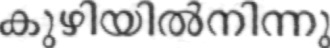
കുഴിയില്‍നിന്നു
